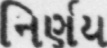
નિર્ણય
